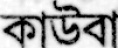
কাউবা
